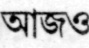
আজও
